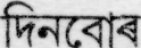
দিনবোৰ
